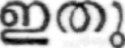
ഇതു
